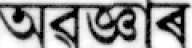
অৱজ্ঞাৰ
